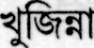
খুজিন্না
